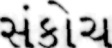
સંકોચ
